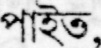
পাইত,
